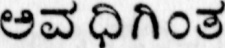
ಅವಧಿಗಿಂತ
